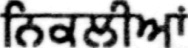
ਨਿਕਲੀਆਂ
